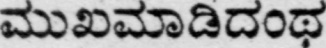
ಮುಖಮಾಡಿದಂಥ
